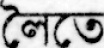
লৈতে
